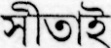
সীতাই
